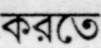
করতে
